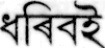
ধৰিবই
